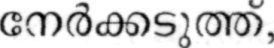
നേര്‍ക്കടുത്ത്,
